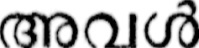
അവള്‍
